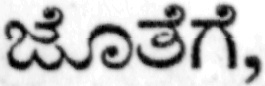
ಜೊತೆಗೆ,
